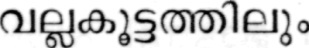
വല്ലകൂട്ടത്തിലും
